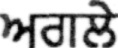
ਅਗਲੇ
